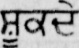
ਸ਼ੂਕਦੇ
